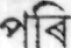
পৰি
